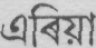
এৰিয়া
